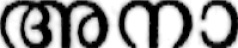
അനാ
